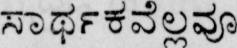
ಸಾರ್ಥಕವೆಲ್ಲವೂ
